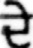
ਦੇ
